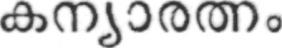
കന്യാരത്നം
